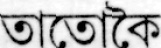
তাতোকৈ
